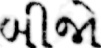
બીજો
